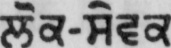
ਲੋਕ-ਸੇਵਕ
